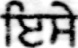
ਇਸੇ
